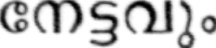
നേട്ടവും
